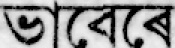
ভাবেৰে
